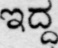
ಇದ್ದ
